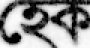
হেক
